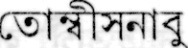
তোম্বীসনাবু
